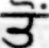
ਤੋਂ
